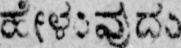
ಹೇಳುವುದು
